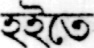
হইতে
